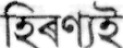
হিৰণ্যই
